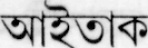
আইতাক
